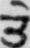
ਤੇ
